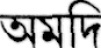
অমদি
